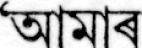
'আমাৰ
